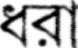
ধরা
